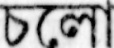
চলো
